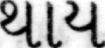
થાય
